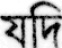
যদি
